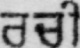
ਰਚੀ
